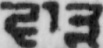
ਵਾੜ
